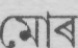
মোৰ
